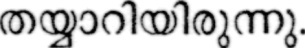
തയ്യാറിയിരുന്നു.
